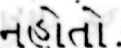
નહોતો.
